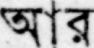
আর
